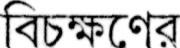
বিচক্ষণের
